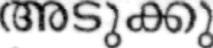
അടുക്കു
